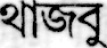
থাজবু
